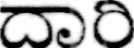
ದಾರಿ
